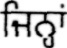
ਜਿਨ੍ਹਾਂ
